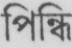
পিন্ধি
